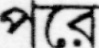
পরে
